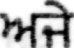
ਅਜੇ
